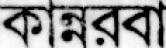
কান্নরবা
